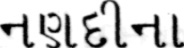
નણદીના
